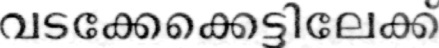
വടക്കേക്കെട്ടിലേക്ക്
